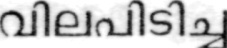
വിലപിടിച്ച
